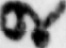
જ
